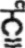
ਨੂੰ
